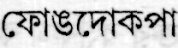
ফোঙদোকপা
